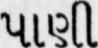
પાણી
